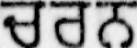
ਚਰਨ
